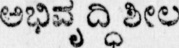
ಅಭಿವೃದ್ಧಿಶೀಲ
